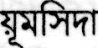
য়ূমসিদা
